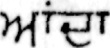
ਆਂਦਾ
